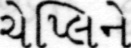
ચેપ્લિને
